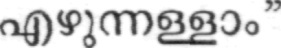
എഴുന്നള്ളാം”
